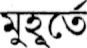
মুহূর্তে
